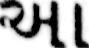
આ
